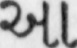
આ
